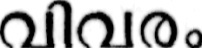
വിവരം
